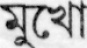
মুখো
